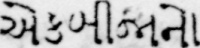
એકબીજાનો
